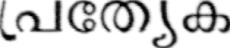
പ്രത്യേക
